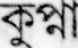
কুপ্না
